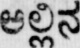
ಅಲ್ಲಿನ
